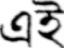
এই
